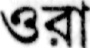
ওরা
